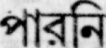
পারনি
